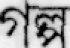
গল্প
